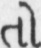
તો
